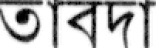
তাবদা
